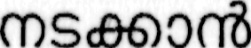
നടക്കാന്‍
